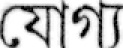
যোগ্য
